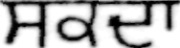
ਸਕਦਾ
